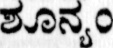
ಶೂನ್ಯಂ
